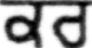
ਕਰ
